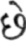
છે
